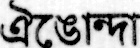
ঐঙোন্দা
